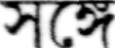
সঙ্গে
